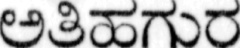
ಅತಿಹಗುರ
